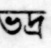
ভদ্র
